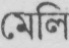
মেলি
